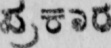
ಪ್ರಕಾರ
